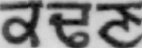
ਕਢਣ
